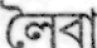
লৈবা
